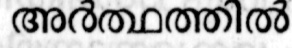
അര്‍ത്ഥത്തില്‍
